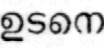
ഉടനെ
